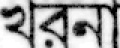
খরনা
